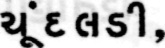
ચૂંદલડી,
